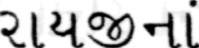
રાયજીનાં
